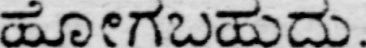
ಹೋಗಬಹುದು.
